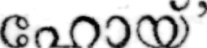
ഹോയ്'
